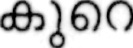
കുറെ
